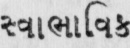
સ્વાભાવિક
